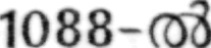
1088-ല്‍
